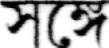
সঙ্গে
